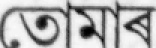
তোমাৰ
